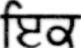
ਇਕ
